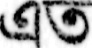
এত
